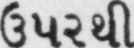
ઉપરથી
